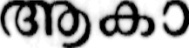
ആകാ
